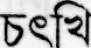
চৎখি
